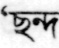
‘ছন্দ
